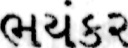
ભયંકર
